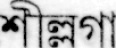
শীল্লগা
